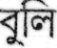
বুলি
